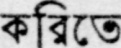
করিতে
